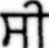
ਸੀ
